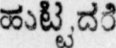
ಹುಟ್ಟಿದರೆ
